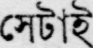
সেটাই
